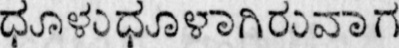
ಧೂಳುಧೂಳಾಗಿರುವಾಗ
